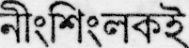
নীংশিংলকই
